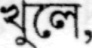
খুলে,
